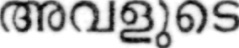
അവളുടെ
